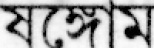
ষঙ্গোম
